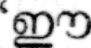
‘ഈ
